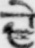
ਦੇ
